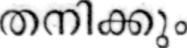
തനിക്കും
